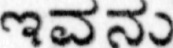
ಇವನು
